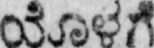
ಯೊಳಗೆ
